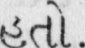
હતો.
